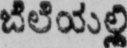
ಬೆಲೆಯಲ್ಲಿ
